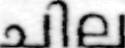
ചില
